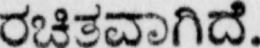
ರಚಿತವಾಗಿದೆ.
